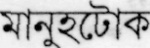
মানুহটোক
